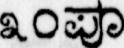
೩೦ಪೂ
